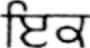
ਇਕ
